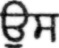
ਉਸ
